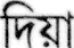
দিয়া
